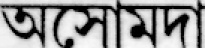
অসোমদা
